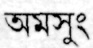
অমসুং
